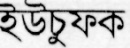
ইউচুফক
